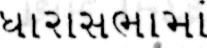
ધારાસભામાં
